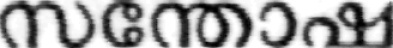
സന്തോഷ
